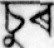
চুৰ
